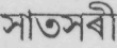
সাতসৰী
